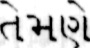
તેમણે
